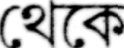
থেকে
